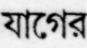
যাগের
